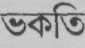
ভকতি
